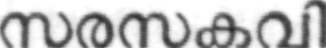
സരസകവി
